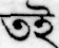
তই
